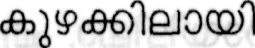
കുഴക്കിലായി
